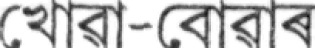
খোৱা-বোৱাৰ
